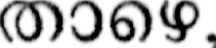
താഴെ,
